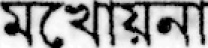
মখোয়না
